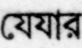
যেযার
